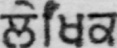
ਲੇਖਿਕ
